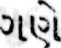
ગણે
